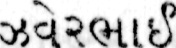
ઝવેરભાઈ
